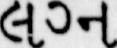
લગ્ન
